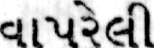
વાપરેલી
